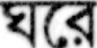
ঘরে
